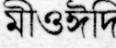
মীওঈদি
